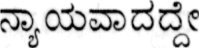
ನ್ಯಾಯವಾದದ್ದೇ
